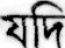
যদি
